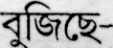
বুজিছে-
